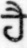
ਹੈ
